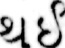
થઈ
